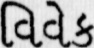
વિવેક
